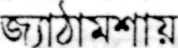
জ্যাঠামশায়
